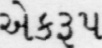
એકરૂપ
